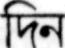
দিন
